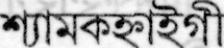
শ্যামকহ্ণাইগী
